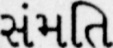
સંમતિ
